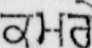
ਕਮਰੇ
